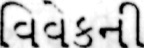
વિવેકની
